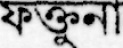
ফক্তুনা
